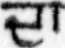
ਦਾ
